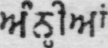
ਅੰਨ੍ਹੀਆਂ
